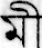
মী
